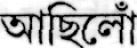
আছিলোঁ
